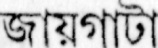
জায়গাটা
